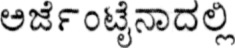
ಅರ್ಜೆಂಟೈನಾದಲ್ಲಿ
